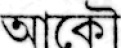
আকৌ
